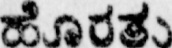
ಹೊರತು
